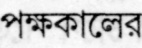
পক্ষকালের
